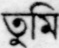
তুমি
